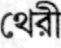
থেরী
